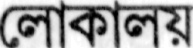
লোকালয়
